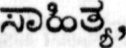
ಸಾಹಿತ್ಯ,
